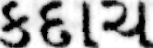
કદાચ
